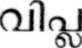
വിപ്ല
